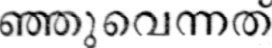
ഞ്ഞുവെന്നത്
